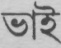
ভাই
